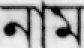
নাম
